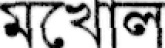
মখোল
